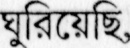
ঘুরিয়েছি,
